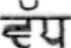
ਵੱਧ
